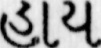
હાય
